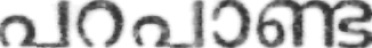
പറപാണ്ട
